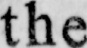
the
